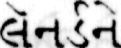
લૅનર્ડને
